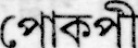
পোকপী
